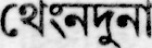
থেনদুনা
